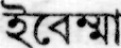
ইবেম্মা
